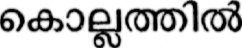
കൊല്ലത്തില്‍
